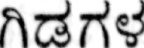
ಗಿಡಗಳ
